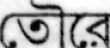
তৌরে
